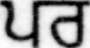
ਪਰ
